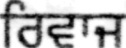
ਰਿਵਾਜ
